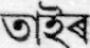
তাইৰ
